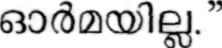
ഓര്‍മയില്ല."
